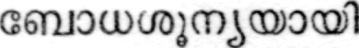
ബോധശൂന്യയായി
